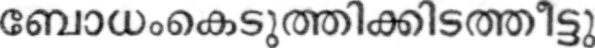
ബോധംകെടുത്തിക്കിടത്തീട്ടു
